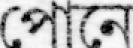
পোনে
